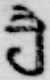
ਹੈ
